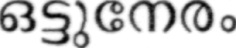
ഒട്ടുനേരം
